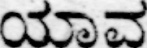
ಯಾವ
